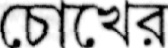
চোখের
